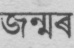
জন্মৰ
